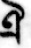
ঐ
